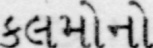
કલમોનો
